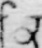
ਕਿ
